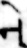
ને
